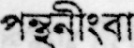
পন্থনীংবা
